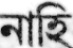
নাহি
